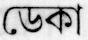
ডেকা
